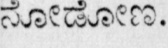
ನೋಡೋಣ.
